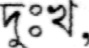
দুঃখ,
